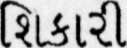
શિકારી
